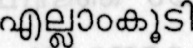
എല്ലാംകൂടി
